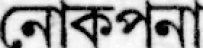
নোকপনা
